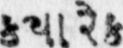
ક્યારેક
